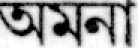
অমনা
